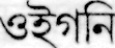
ওইগনি
